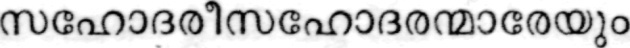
സഹോദരീസഹോദരന്മാരേയും
